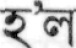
হ'ল
